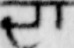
ਦਾ
